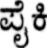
ಪೈಕಿ
